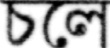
চলে
